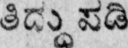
ತಿದ್ದುಪಡಿ
